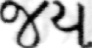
જય
